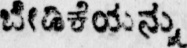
ಬೇಡಿಕೆಯನ್ನು
